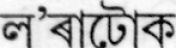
ল'ৰাটোক
